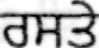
ਰਸਤੇ
